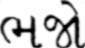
ભજો
